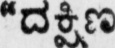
“ದಕ್ಷಿಣ
